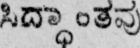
ಸಿದ್ದಾಂತವು
